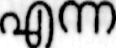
എന്ന
